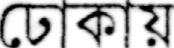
ঢোকায়
